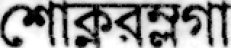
শোক্নরম্লগা
